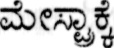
ಮೇಸ್ಟ್ರಾಕ್ಕೆ
